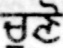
ਚੁਣੋ
